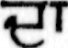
ਦਾ
